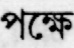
পক্ষে
